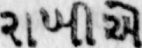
રાખીએ
